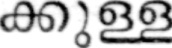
ക്കുള്ള
